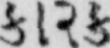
કારક
